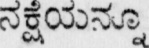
ನಕ್ಷೆಯನ್ನೂ
